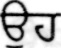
ਉਹ
